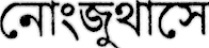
নোংজুথাসে
